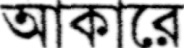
আকারে
